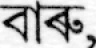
বাৰু,
